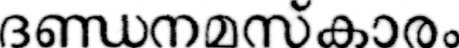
ദണ്ഡനമസ്കാരം
